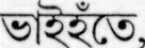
ভাইহঁতে,
